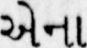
એના
